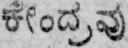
ಕೇಂದ್ರವು
